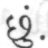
છું.
